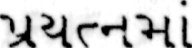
પ્રયત્નમાં
